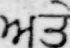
ਅਤੇ
